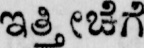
ಇತ್ತೀಚೆಗೆ
